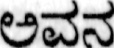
ಅವನ
